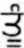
ਤੂੰ
